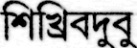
শিখ্রিবদুবু
